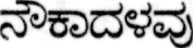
ನೌಕಾದಳವು
